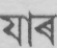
যাৰ
